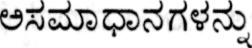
ಅಸಮಾಧಾನಗಳನ್ನು
